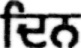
ਦਿਨ
